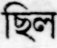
ছিল
